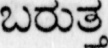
ಬರುತ್ತ
